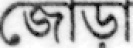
জোড়া
